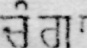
ਚੰਗਾ
